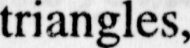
triangles,
